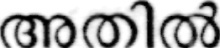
അതില്‍
